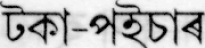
টকা-পইচাৰ
